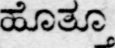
ಹೊತ್ತೂ
